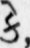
કે,
